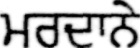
ਮਰਦਾਨੇ
